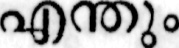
എന്തും
